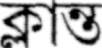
ক্লান্ত
